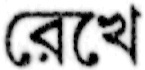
রেখে
